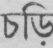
চড়ি
